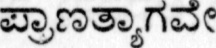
ಪ್ರಾಣತ್ಯಾಗವೇ
